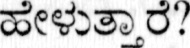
ಹೇಳುತ್ತಾರೆ?
